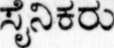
ಸೈನಿಕರು
